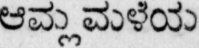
ಆಮ್ಲಮಳೆಯ
